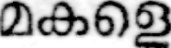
മകളെ
